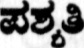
ಪಶ್ಯತಿ
